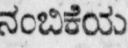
ನಂಬಿಕೆಯ
